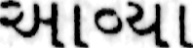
આવ્યા
